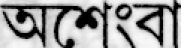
অশেংবা
